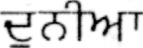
ਦੁਨੀਆ
